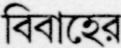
বিবাহের
